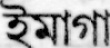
ইমাগা
